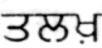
ਤਲਖ਼
